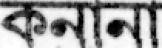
কনানা
